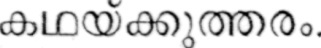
കഥയ്ക്കുത്തരം.
